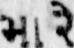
મારે
